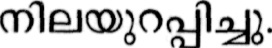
നിലയുറപ്പിച്ചു.
